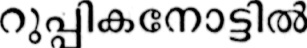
റുപ്പികനോട്ടില്‍
